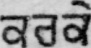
ਕਰਕੇ
